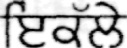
ਇਕੱਲੇ
